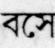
বসে
